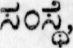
ಸಂಸ್ಥೆ,
